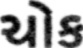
ચોક
